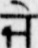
ਜੇ
